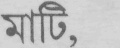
মাটি,
